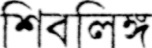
শিবলিঙ্গ
